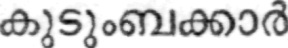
കുടുംബക്കാര്‍
